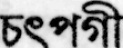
চৎপগী
